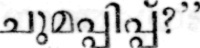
ചുമപ്പിപ്പ്?"
